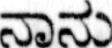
ನಾನು
